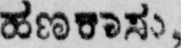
ಹಣಕಾಸು,
